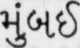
મુંબઈ
